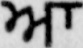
ਆ
